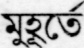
মুহূর্তে
